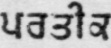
ਪਰਤੀਕ
